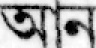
আন
